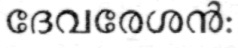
ദേവരേശന്‍:
